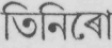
তিনিৰো
